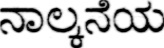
ನಾಲ್ಕನೆಯ
